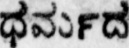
ಧರ್ಮದ
